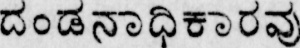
ದಂಡನಾಧಿಕಾರವು
